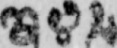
ಇಳಿಸಿ
